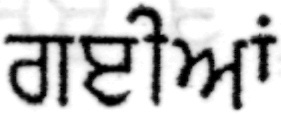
ਗਈਆਂ
